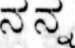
ನನ್ನ
